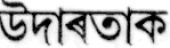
উদাৰতাক
